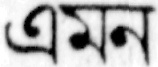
এমন
